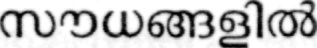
സൌധങ്ങളില്‍
